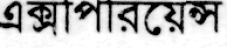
এক্সপিরিয়েন্স
